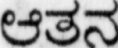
ಆತನ
